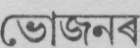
ভোজনৰ
